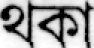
থকা
